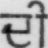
ਦੀ
